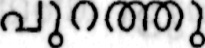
പുറത്തു
